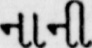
નાની
